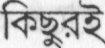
কিছুরই
